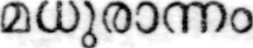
മധുരാന്നം
